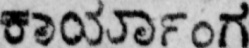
ಕಾರ್ಯಾಂಗ
